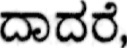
ದಾದರೆ,
